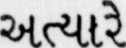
અત્યારે
